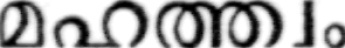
മഹത്ത്വം
